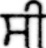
ਸੀ
